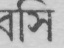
বসি
